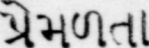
પ્રેમળતા
